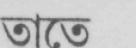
তাতে
